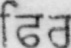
ਫਿਰ
